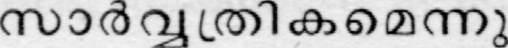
സാര്‍വ്വത്രികമെന്നു
